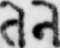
તેને
